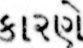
કારણે
